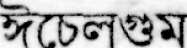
ঈচেলগুম
